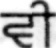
ਵੀ
